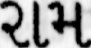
રામ
